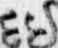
દઈ
